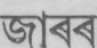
জাৰৰ
